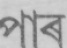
পাৰ
